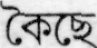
কৈছে
